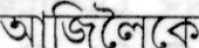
আজিলৈকে
